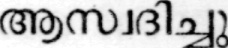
ആസ്വദിച്ചു
